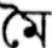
মৈ
